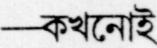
–কখনোই
